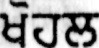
ਖੋਹਲ
